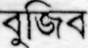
বুজিব
